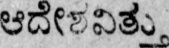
ಆದೇಶವಿತ್ತು.
